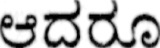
ಆದರೂ
